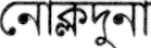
নোক্লদুনা
